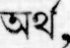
অর্থ,
